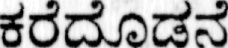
ಕರೆದೊಡನೆ
